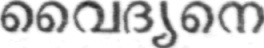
വൈദ്യനെ
